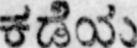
ಕಡೆಯ
